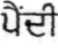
ਪੈਂਦੀ
